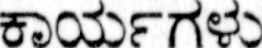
ಕಾರ್ಯಗಳು
